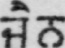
ਜੈਨ
